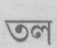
তল
